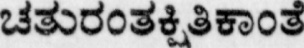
ಚತುರಂತಕ್ಷಿತಿಕಾಂತೆ
